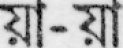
য়া-য়া
